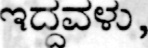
ಇದ್ದವಳು,
